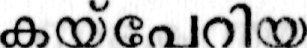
കയ്പേറിയ
